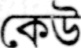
কেউ
